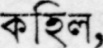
কহিল,
